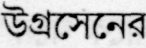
উগ্রসেনের
